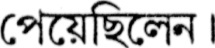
পেয়েছিলেন।
